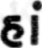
હાં
